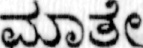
ಮಾತೇ
